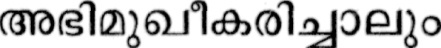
അഭിമുഖീകരിച്ചാലും
